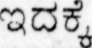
ಇದಕ್ಕೆ
